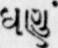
ઘણું
